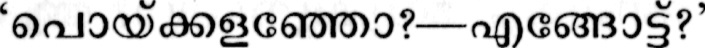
‘പൊയ്ക്കളഞ്ഞോ?-എങ്ങോട്ട്?’
